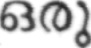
ഒരു
